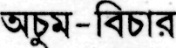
অচুম-বিচার
